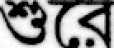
শুরে
